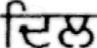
ਦਿਲ
